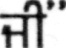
ਜੀ''
